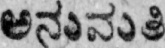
ಅನುಮತಿ
